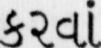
કરવાં
